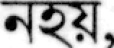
নহয়,
